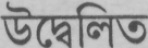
উদ্বেলিত
